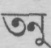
তনু
